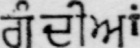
ਗੰਦੀਆਂ
